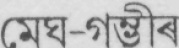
মেঘ-গম্ভীৰ
